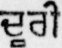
ਦੂਰੀ
